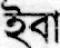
ইবা
